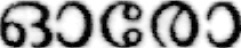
ഓരോ
